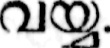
വയ്യ.
